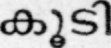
കൂടി
